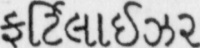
ફર્ટિલાઈઝર
